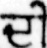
ਦੀ
